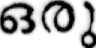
ഒരു
